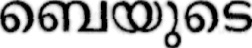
ബെയുടെ
